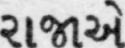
રાજાએ
